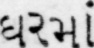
ઘરમાં
